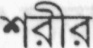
শরীর
